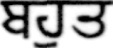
ਬਹੁਤ
